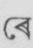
ৰে
